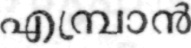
എമ്പ്രാന്‍
